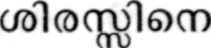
ശിരസ്സിനെ
